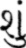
શું
